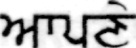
ਆਪਣੇ
